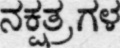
ನಕ್ಷತ್ರಗಳ
